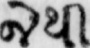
જેથી
